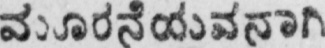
ಮೂರನೆಯವನಾಗಿ
